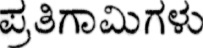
ಪ್ರತಿಗಾಮಿಗಳು
